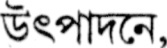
উৎপাদনে,
